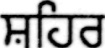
ਸ਼ਹਿਰ
